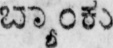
ಬ್ಯಾಂಕು
